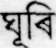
ঘূৰি
